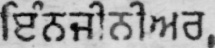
ਇੰਨਜੀਨੀਅਰ,
